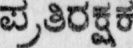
ಪ್ರತಿರಕ್ಷಕ
